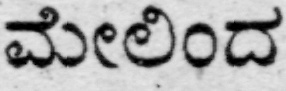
ಕಾರಣಕೊಟ್ಟ್ಲು
